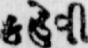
કહેવી
